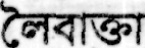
লৈবাক্তা
